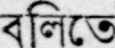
বলিতে
